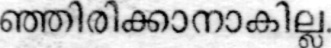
ഞ്ഞിരിക്കാനാകില്ല.
